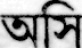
অসি
